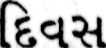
દિવસ
